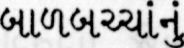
બાળબચ્ચાંનું
